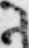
ને
